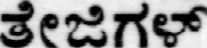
ತೇಜಿಗಳ್
